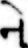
ને
